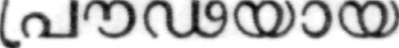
പ്രൌഢയായ
